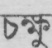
চক্ষু
